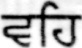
ਵਹਿ
